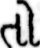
તો
